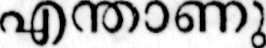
എന്താണു
